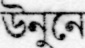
উনুনে
